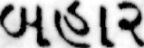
બહાર
